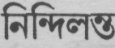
নিন্দিলন্ত
